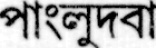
পাংলুদবা
